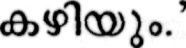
കഴിയും.’
